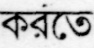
করতে
